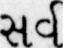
સર્વ
